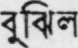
বুঝিল
